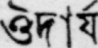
ঔদার্য
